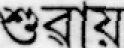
শুৱায়
